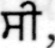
ਸੀ,
